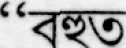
"বহুত
